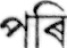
পৰি
